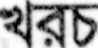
খরচ
